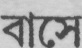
বাসে
